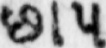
છાપ
